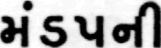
મંડપની
